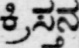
ಕ್ರಿಸ್ತನ
